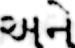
અને
